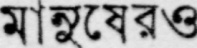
মানুষেরও
